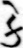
કે
